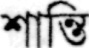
শান্তি
